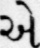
એ
